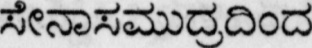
ಸೇನಾಸಮುದ್ರದಿಂದ
